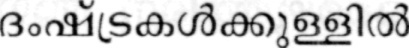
ദംഷ്ട്രകള്‍ക്കുള്ളില്‍
